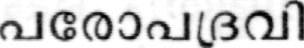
പരോപദ്രവി
